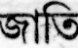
জাতি
